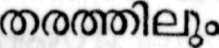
തരത്തിലും
